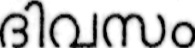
ദിവസം
